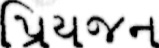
પ્રિયજન
